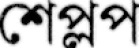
শেপ্লপ
